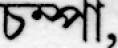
চম্পা,
